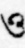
ও
